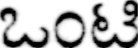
ಒಂಟಿ
